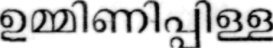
ഉമ്മിണിപ്പിള്ള
